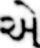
એ
